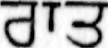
ਰਾਤ
